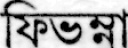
ফিভম্না
